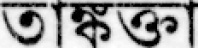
তাঙ্কক্তা
